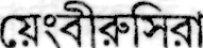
য়েংবীরুসিরা
